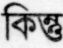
কিন্তু
